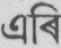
এৰি
